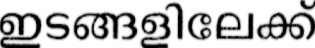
ഇടങ്ങളിലേക്ക്
